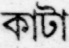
কাটা
